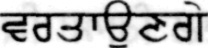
ਵਰਤਾਉਣਗੇ
